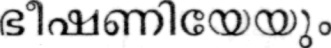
ഭീഷണിയേയും
